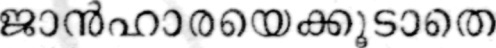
ജാന്‍ഹാരയെക്കൂടാതെ
